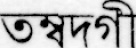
তম্বদগী
